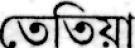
তেতিয়া
